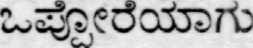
ಒಪ್ಪೋರೆಯಾಗು
